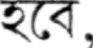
হবে,
